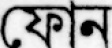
ফোন
